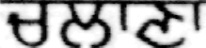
ਚਲਾਣਾ
